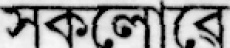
সকলোৱে
